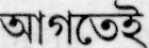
আগতেই
